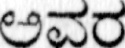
ಅವರ
